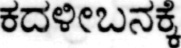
ಕದಳೀಬನಕ್ಕೆ
